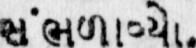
સંભળાવ્યો.
